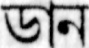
ডান
